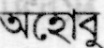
অহোবু
